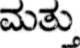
ಮತ್ತು
